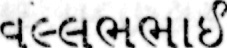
વલ્લભભાઈ
